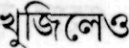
খুজিলেও
